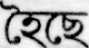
হৈছে
